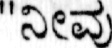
“ನೀವು
